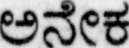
ಅನೇಕ
